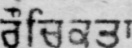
ਰੌਚਿਕਤਾ
